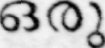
ഒരു
